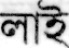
লাই
